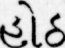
હોઠ
